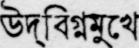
উদ্‌বিগ্নমুখে
